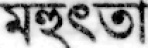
মহুৎতা
